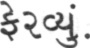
ફેરવ્યું.
